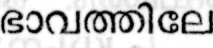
ഭാവത്തിലേ
